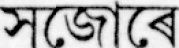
সজোৰে
